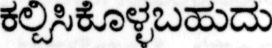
ಕಲ್ಪಿಸಿಕೊಳ್ಳಬಹುದು
